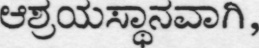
ಆಶ್ರಯಸ್ಥಾನವಾಗಿ,
